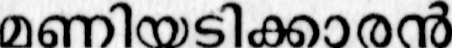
മണിയടിക്കാരന്‍
